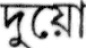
দুয়ো
